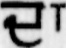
ਦਾ
